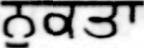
ਨੁਕਤਾ
